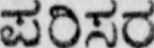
ಪರಿಸರ
